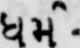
ધર્મ-
